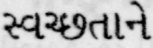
સ્વચ્છતાને
